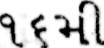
૧૬મી
